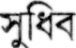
সুধিব
